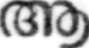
ആ
